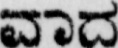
ವಾದ
